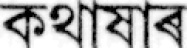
কথাষাৰ
